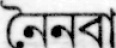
নৈনবা
